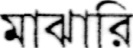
মাঝারি
